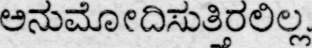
ಅನುಮೋದಿಸುತ್ತಿರಲಿಲ್ಲ.
